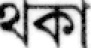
থকা
